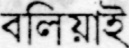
বলিয়াই
